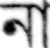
না
